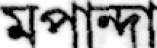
মপান্দা
